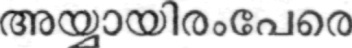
അയ്യായിരംപേരെ
